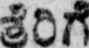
ತೆರಿಗೆ
